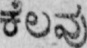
ಕೆಲವು
